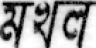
মখুল
